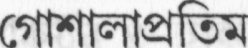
গোশালাপ্রতিম
